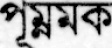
পূম্নমক
